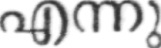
എന്നു
